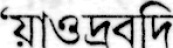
‘য়াওদ্রবদি
